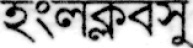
হংলক্লবসু
